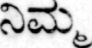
ನಿಮ್ಮ
